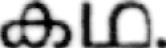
കഥ.
